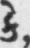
કે,
